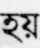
হয়
